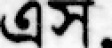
এস,
